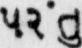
પરંતુ
